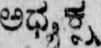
ಅಧ್ಯಕ್ಷ
